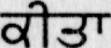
ਕੀਤਾ
